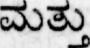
ಮತ್ತು
